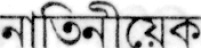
নাতিনীয়েক
